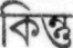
কিন্তু
